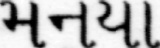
મનયા
